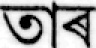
তাৰ
